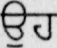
ਉਹ
